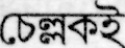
চেল্লকই
